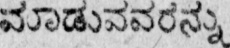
ಮಾಡುವವರನ್ನು
